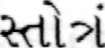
સ્તોત્રં
